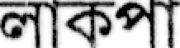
লাকপা
